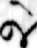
જે
